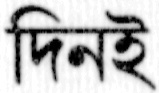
দিনই
